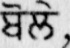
ਬੋਲੇ,
